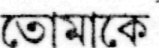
তোমাকে
